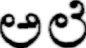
ಅಲೆ
